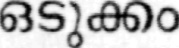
ഒടുക്കം
